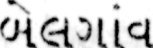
બેલગાંવ
